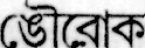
ঙৌরোক
